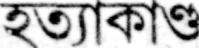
হত্যাকাণ্ড
